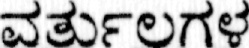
ವರ್ತುಲಗಳ
